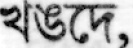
খঙদে,
